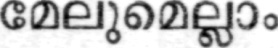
മേലുമെല്ലാം
